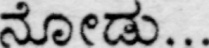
ನೋಡು..
